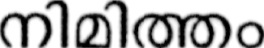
നിമിത്തം
